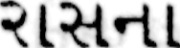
રાસના
